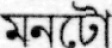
মনটো
